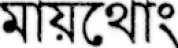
মায়থোং
